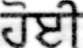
ਹੋਈ
